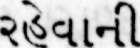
રહેવાની
